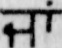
ਜਾਂ
